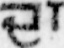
ਦਾ
